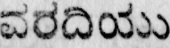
ವರದಿಯು
